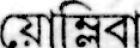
য়োম্লিবা
